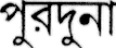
পুরদুনা
